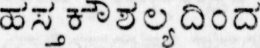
ಹಸ್ತಕೌಶಲ್ಯದಿಂದ
